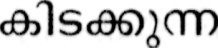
കിടക്കുന്ന
